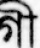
গী
